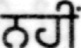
ਨਹੀਂ
